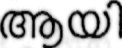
ആയി
